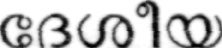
ദേശീയ
